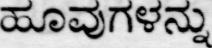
ಹೂವುಗಳನ್ನು
